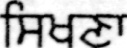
ਸਿਖਣਾ
